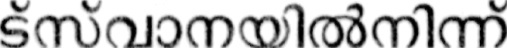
ട്സ്വാനയില്‍നിന്ന്
